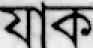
যাক
